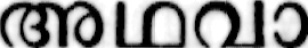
അഥവാ
